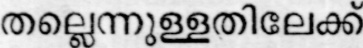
തല്ലെന്നുള്ളതിലേക്ക്
